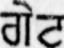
ਗੇਟ
